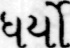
ધર્યો
